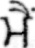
ਮੈਂ
